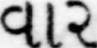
વાર
